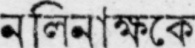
নলিনাক্ষকে
